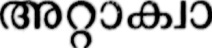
അറ്റാക്വാ
